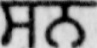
ਸਨ
